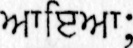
ਆਇਆ;
